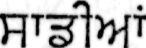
ਸਾਡੀਆਂ
